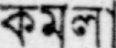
কমলা
